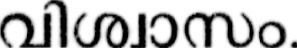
വിശ്വാസം.
